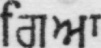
ਗਿਆ
